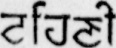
ਟਹਿਣੀ
